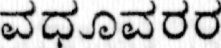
ವಧೂವರರ
